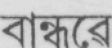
বান্ধৱে
